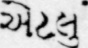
એટલું
